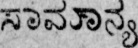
ಸಾಮಾನ್ಯ
